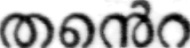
തന്റെ
